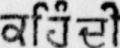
ਕਹਿੰਦੀ
